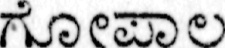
ಗೋಪಾಲ
